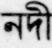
নদী
